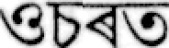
ওচৰত
